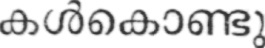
കള്‍കൊണ്ടു
